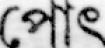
পোৎ
